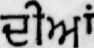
ਦੀਆਂ
